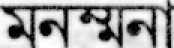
মনম্মনা
